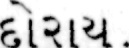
દોરાય.
